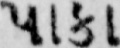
પાકા
